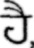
ਹੈ,
